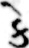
કે
